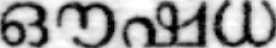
ഔഷധ
